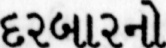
દરબારનો
